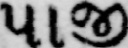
પાજી
